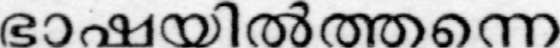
ഭാഷയില്‍ത്തന്നെ
